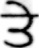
ਤੇ
